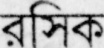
রসিক
